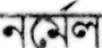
নর্মেল
